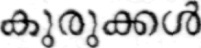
കുരുക്കള്‍
